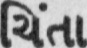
ચિંતા
